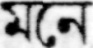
মনে
